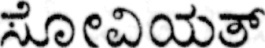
ಸೋವಿಯತ್
